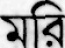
মরি
